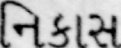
નિકાસ
